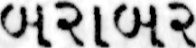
બરાબર
